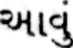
આવું
